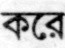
করে
